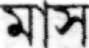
মাস
